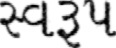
સ્વરૂપ
